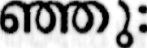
ഞ്ഞു:
